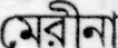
মেরীনা
